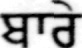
ਬਾਰੇ
